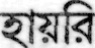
হায়রি
